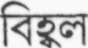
বিহ্বল
